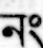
নং
